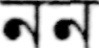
নন
